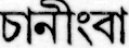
চানীংবা
